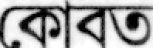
কোবত
